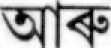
আৰু
